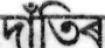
দাঁতিৰ
